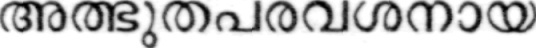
അത്ഭുതപരവശനായ
